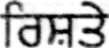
ਰਿਸ਼ਤੇ
